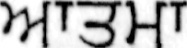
ਆਤਮਾ
